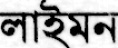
লাইমন
